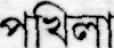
পখিলা
